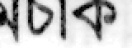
মচাক
